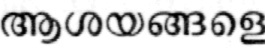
ആശയങ്ങളെ
